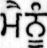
ਮੈਨੂੰ
